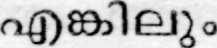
എങ്കിലും
